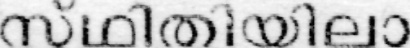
സ്ഥിതിയിലാ
